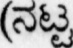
(ನಟ್ಟ
